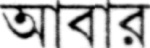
আবার
